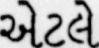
એટલે
